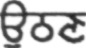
ਉਠਣ
